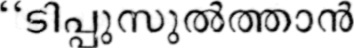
"ടിപ്പുസുല്‍ത്താന്‍
